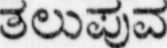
ತಲುಪುವ
